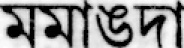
মমাঙদা
